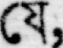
যে,
